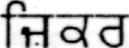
ਜ਼ਿਕਰ
